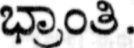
ಭ್ರಾಂತಿ.
